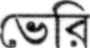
ভেরি
